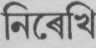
নিৰেখি
